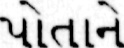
પોતાને
